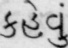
કહેવું
